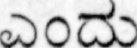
ಎಂದು
